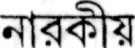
নারকীয়
